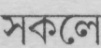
সকলে
